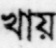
খায়
